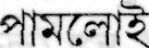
পামলোই
